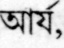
আর্য,
